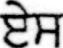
ਏਸ
